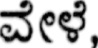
ವೇಳೆ,
